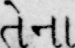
તેના
